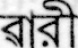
ৱারী
